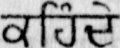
ਕਹਿੰਦੇ
